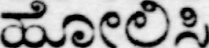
ಹೋಲಿಸಿ
